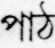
পাঠ
